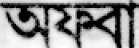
অফবা
